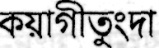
কয়াগীতুংদা
